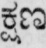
ಕ್ಷಣ
